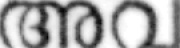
അവ
